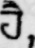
ਹੈ,
